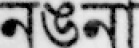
নঙনা
